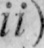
ii)
